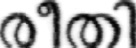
രീതി
